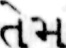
તેમ
